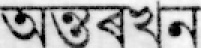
অন্তৰখন
